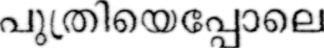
പുത്രിയെപ്പോലെ
